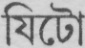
যিটো
